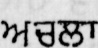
ਅਚਲਾ
